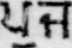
ਪੁਜ
